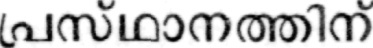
പ്രസ്ഥാനത്തിന്
